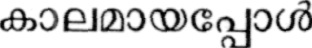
കാലമായപ്പോള്‍
